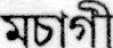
মচাগী
